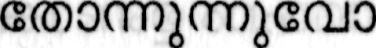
തോന്നുന്നുവോ
